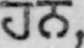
ਹਨ,
